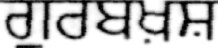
ਗੁਰਬਖ਼ਸ਼
